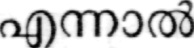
എന്നാല്‍
